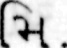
મિ.
